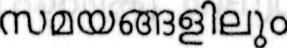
സമയങ്ങളിലും
